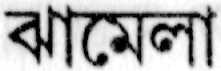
ঝামেলা
